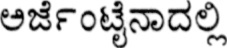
ಅರ್ಜೆಂಟೈನಾದಲ್ಲಿ
